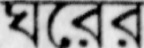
ঘরের
